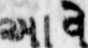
આવે
